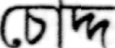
চোদ্দ
